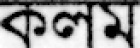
কলম
